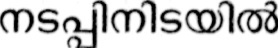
നടപ്പിനിടയില്‍
